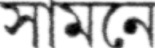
সামনে
